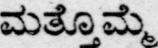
ಮತ್ತೊಮ್ಮೆ
